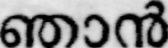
ഞാന്‍
